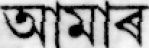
আমাৰ
